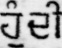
ਹੁੰਦੀ
